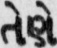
તેણે
